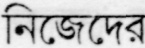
নিজেদের
